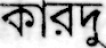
কারদু
